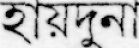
হায়দুনা
